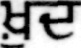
ਖ਼ੁਦ
